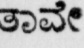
ತಾವೇ
